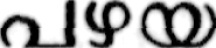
പഴയ
